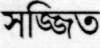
সজ্জিত
